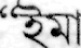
“ইমা
